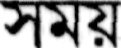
সময়
